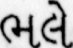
ભલે
